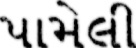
પામેલી
